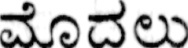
ಮೊದಲು
